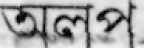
অলপ
